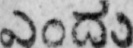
ಎಂದು
